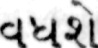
વધશે
